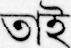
তাই
